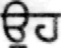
ਉਹ
